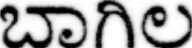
ಬಾಗಿಲ
